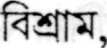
বিশ্রাম,
